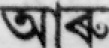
আৰু
